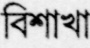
বিশাখা
